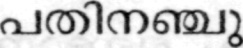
പതിനഞ്ചു
